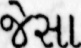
જેસા
